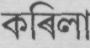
কৰিলা
